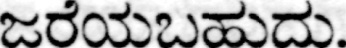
ಜರೆಯಬಹುದು.
